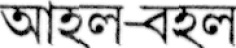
আহল-বহল
